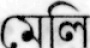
মেলি
